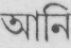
আনি
